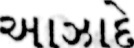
આઝાદે
